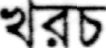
খরচ
